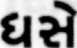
ધસે
